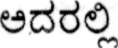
ಅದರಲ್ಲಿ
